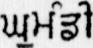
ਘੁਮੰਡੀ
